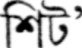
শিট’
